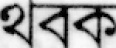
থবক
